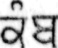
ਕੰਬ
